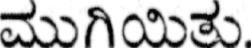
ಮುಗಿಯಿತು.
